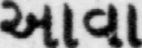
આવા
